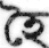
হৈ
